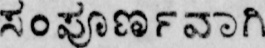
ಸಂಪೂರ್ಣವಾಗಿ
